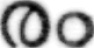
രം
